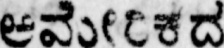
ಅಮೇರಿಕದ
